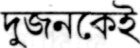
দুজনকেই
